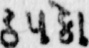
ઠપકો
